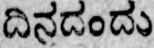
ದಿನದಂದು
